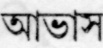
আভাস
